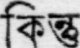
কিন্তু
